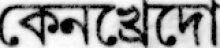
কেনখ্রদো
